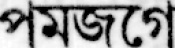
পমজগে
